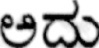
ಅದು
